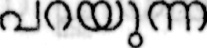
പറയുന്ന
